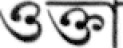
ওক্তা
